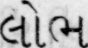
લોભ
